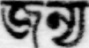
জন্য
